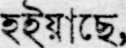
হইয়াছে,
